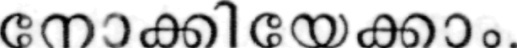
നോക്കിയേക്കാം.
